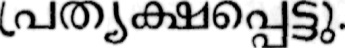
പ്രത്യക്ഷപ്പെട്ടു.
